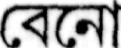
বেনো
